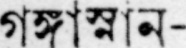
গঙ্গাস্নান-
